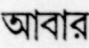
আবার
